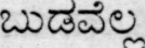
ಬುಡವೆಲ್ಲ
